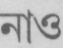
নাও
